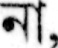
না,
